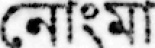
নোংমা
